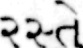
રસ્તે
